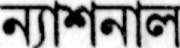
ন্যাশনাল
